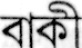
বাকী
